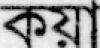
কয়া
